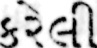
કરેલી
